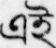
এই
